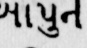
બાપુને
